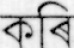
কৰি
